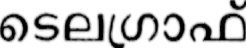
ടെലഗ്രാഫ്
